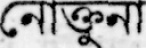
নোক্তুনা
